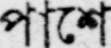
পাশে
